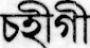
চহীগী
